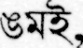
ঙমই,
